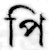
পি
